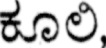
ಕೂಲಿ,
